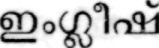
ഇംഗ്ലീഷ്
